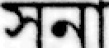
সনা
